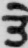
ਤੇ
